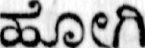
ಹೋಗಿ
